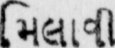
મિલાવી
